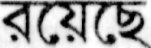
রয়েছে
